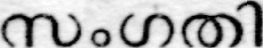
സംഗതി
